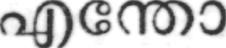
എന്തോ
